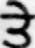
ਤੇ
